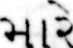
મારે
